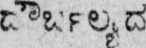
ದೌರ್ಬಲ್ಯದ
